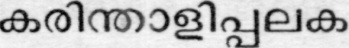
കരിന്താളിപ്പലക
